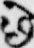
છે
